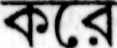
করে
